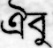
ঐবু
